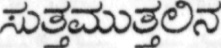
ಸುತ್ತಮುತ್ತಲಿನ
